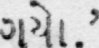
ગયો.'
